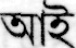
আই
